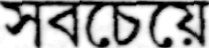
সবচেয়ে
